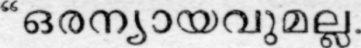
"ഒരന്യായവുമല്ല.
